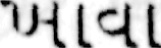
ખાવા
